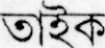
তাইক
